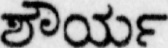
ಶೌರ್ಯ
